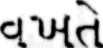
વખતે
